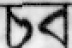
চব
